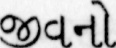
જીવનો
